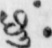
છું.
